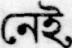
নেই,
